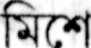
মিশে
